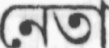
নেতা
